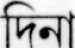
দিনা
